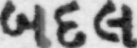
બદલ
